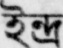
ইন্দ্র
